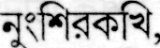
নুংশিরকখি,
